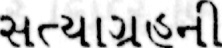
સત્યાગ્રહની
